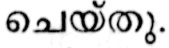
ചെയ്തു.
